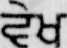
ਵੇਖ
